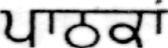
ਪਾਠਕਾਂ
